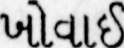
ખોવાઈ
